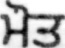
ਮੌਤ
